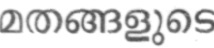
മതങ്ങളുടെ
